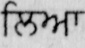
ਲਿਆ
